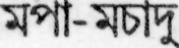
মপা-মচাদু
